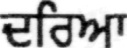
ਦਰਿਆ
